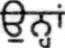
ਉਨ੍ਹਾਂ
